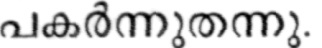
പകര്‍ന്നുതന്നു.
